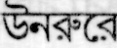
উনরুরে
